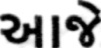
આજે
